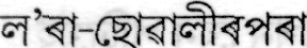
ল'ৰা-ছোৱালীৰপৰা
